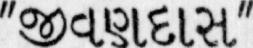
"જીવણદાસ"
